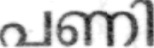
പണി
